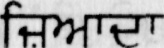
ਜ਼ਿਆਦਾ
